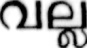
വല്ല
